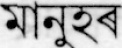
মানুহৰ
